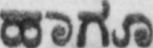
ಹಾಗೂ
